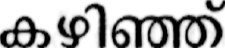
കഴിഞ്ഞ്
